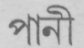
পানী
